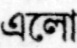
এলো
